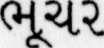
ભૂચર
